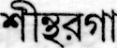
শীন্থরগা
